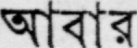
আবার
